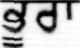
ਭੂਰਾ
